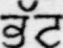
ਭੱਟ
